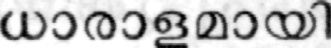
ധാരാളമായി
